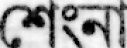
শেংনা
